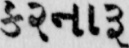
કરનારૂ
